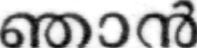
ഞാന്‍
